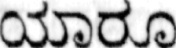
ಯಾರೂ
